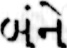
બંને
